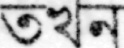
তখন
